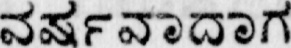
ವರ್ಷವಾದಾಗ
